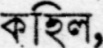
কহিল,
